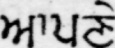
ਆਪਣੇ
